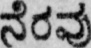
ನೆರವು
